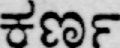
ಕರ್ಣ
